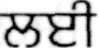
ਲਈ
